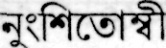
নুংশিতোম্বী
